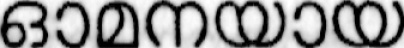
ഓമനയായ
